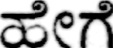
ಹೇಗೆ
